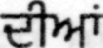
ਦੀਆਂ
